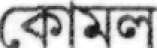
কোমল
